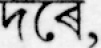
দৰে,
